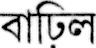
বাঢ়িল
